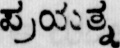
ಪ್ರಯತ್ನ
